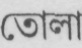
তোলা
